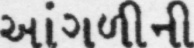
આંગળીની
